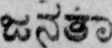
ಜನತಾ
